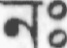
নঃ
